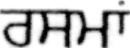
ਰਸਮਾਂ
